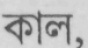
কাল,
